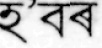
হ'বৰ
